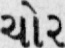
ચોર
